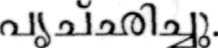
പൃച്ഛിച്ചു.
